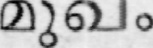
മുഖം
